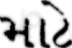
માટે
